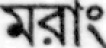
মরাং
